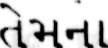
તેમના
